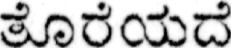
ತೊರೆಯದೆ
